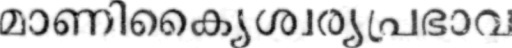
മാണിക്യൈശ്വര്യപ്രഭാവ
